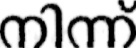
നിന്ന്
